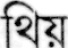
থিয়
